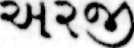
અરજી
